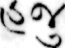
હજુ
